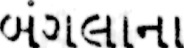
બંગલાને
